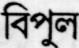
বিপুল
